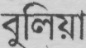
বুলিয়া
